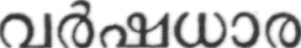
വര്‍ഷധാര
